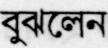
বুঝলেন
